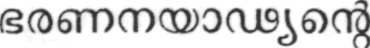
ഭരണനയാഢ്യന്റെ
